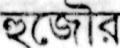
হুজৌর
